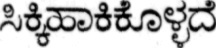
ಸಿಕ್ಕಿಹಾಕಿಕೊಳ್ಳದೆ
